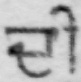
ਦੀ
